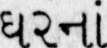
ઘરનાં
